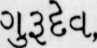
ગુરૂદેવ,
